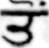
ਤੋਂ
